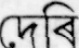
দেৰি
